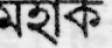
মহাক
